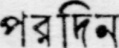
পরদিন
